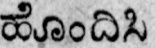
ಹೊಂದಿಸಿ
